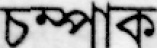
চম্পাক
